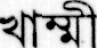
খাম্মী
